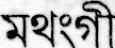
মথংগী
